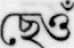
ছেওঁ
